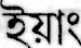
ইয়াং
